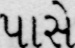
પાસે
